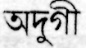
অদুগী
